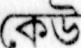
কেউ
